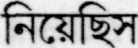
নিয়েছিস
